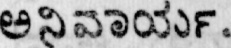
ಅನಿವಾರ್ಯ.
